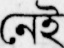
নেই
